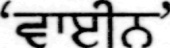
'ਵਾਈਨ'
